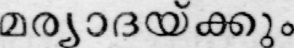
മര്യാദയ്ക്കും
